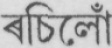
ৰচিলোঁ
